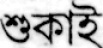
শুকাই
